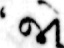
'જો
